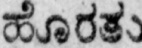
ಹೊರತು
